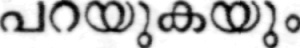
പറയുകയും
